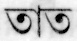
তাত
